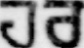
ਹਰ
